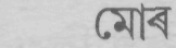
মোৰ
